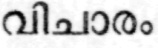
വിചാരം
